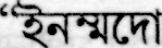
“ইনম্মদো
